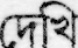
দেখি
